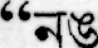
“নঙ
